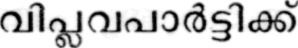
വിപ്ലവപാര്‍ട്ടിക്ക്
